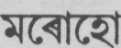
মৰোহো
